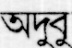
অদুবু
